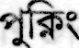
পুক্নিং
